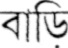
বাড়ি
